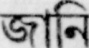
জানি
